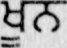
ਖੂਨ
